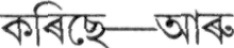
কৰিছে-আৰু
